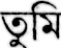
তুমি
